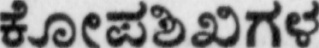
ಕೋಪಶಿಖಿಗಳ
